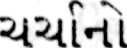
ચર્ચાનો
